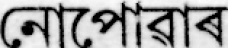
নোপোৱাৰ
